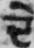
ਦੇ
